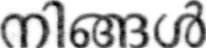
നിങ്ങള്‍
